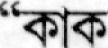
"কাক
